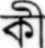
কী
